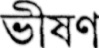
ভীষণ
